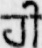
ਹੀ
